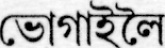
ভোগাইলৈ
